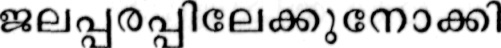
ജലപ്പരപ്പിലേക്കുനോക്കി
